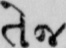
તેજ
